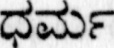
ಧರ್ಮ
